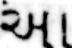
આ
